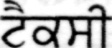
ਟੈਕਸੀ
